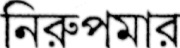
নিরুপমার
